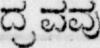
ದ್ರವವು
